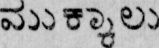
ಮುಕ್ಕಾಲು
